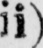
ii)
